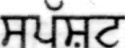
ਸਪੱਸ਼ਟ
